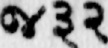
જરૂર
